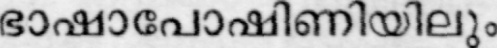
ഭാഷാപോഷിണിയിലും
